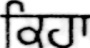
ਕਿਹਾ
